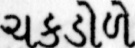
ચકડોળે
